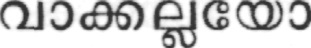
വാക്കല്ലയോ
